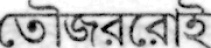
তৌজররোই
